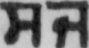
ਸਜ
